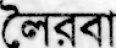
লৈরবা
